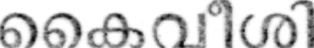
കൈവീശി
